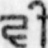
ਵੀ
